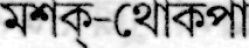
মশক্-থোকপা
